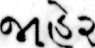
જાહેર
